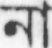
না
